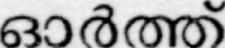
ഓര്‍ത്ത്
